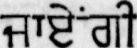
ਜਾਏਂਗੀ
